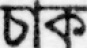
চাক
